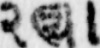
રહ્યા
